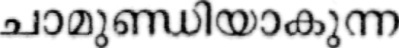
ചാമുണ്ഡിയാകുന്ന
